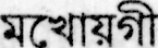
মখোয়গী
